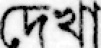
দেখা
